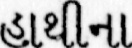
હાથીના
